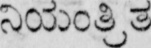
ನಿಯಂತ್ರಿತ
